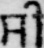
ਸੀ
